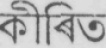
কীৰিত
